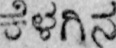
ಕೆಳಗಿನ
